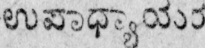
ಉಪಾಧ್ಯಾಯರ
